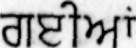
ਗਈਆਂ
